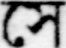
সে
